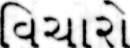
વિચારો
